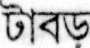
টাবড়
